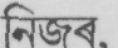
নিজৰ,
